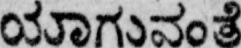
ಯಾಗುವಂತೆ
